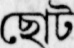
ছোট
